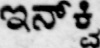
ಇನ್‌ಕ್ವಿ
